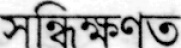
সন্ধিক্ষণত
